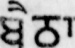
ਬੈਠਾ
